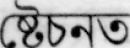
ষ্টেচনত
